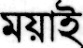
ময়াই
